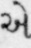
એ
